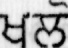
ਖਲੋ
